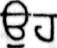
ਉਹ
